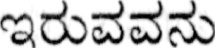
ಇರುವವನು
